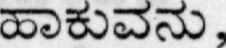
ಹಾಕುವನು,
